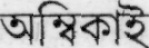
অম্বিকাই
